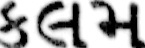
કલમ
